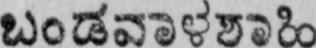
ಬಂಡವಾಳಶಾಹಿ
